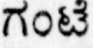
ಗಂಟೆ
